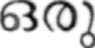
ഒരു
